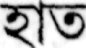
হাত
